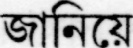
জানিয়ে
